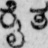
ರೈತ
